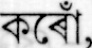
কৰোঁ,
